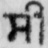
ਸੀ
